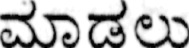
ಮಾಡಲು
